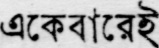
একেবারেই
